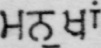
ਮਨੁਖਾਂ
